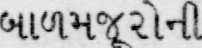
બાળમજૂરોની
